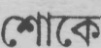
শোকে
